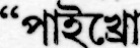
“পাইখ্রো
